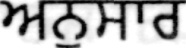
ਅਨੁਸਾਰ
